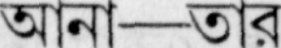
আনা-তার
